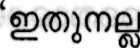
'ഇതുനല്ല
